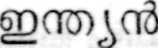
ഇന്ത്യന്‍
